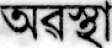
অৱস্থা
